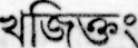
খজিক্তং
